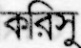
করিসু
